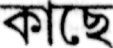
কাছে
